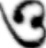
ও
